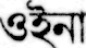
ওইনা
